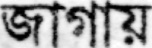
জাগায়
